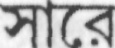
সারে
